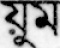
য়ুম
